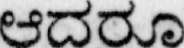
ಆದರೂ
